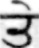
ਤੇ
